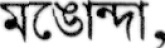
মঙোন্দা,
